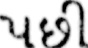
પછી
